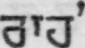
ਰਾਹ'
